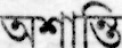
অশান্তি
